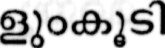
ളുംകൂടി
